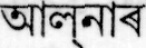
আলনাৰ
